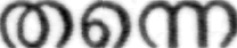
തന്നെ
